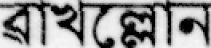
ৱাখল্লোন
